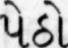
પેઠો
